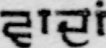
ਵਾਦਾਂ
